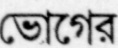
ভোগের
